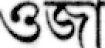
ওজা
